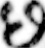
છ
